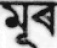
মূৰ
